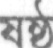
ষষ্ঠ
